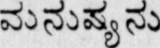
ಮನುಷ್ಯನು
